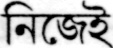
নিজেই
